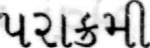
પરાક્રમી
